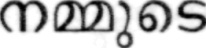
നമ്മുടെ
